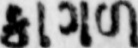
કાગળ
